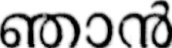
ഞാന്‍
